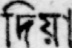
দিয়া
